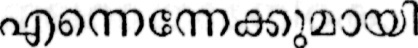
എന്നെന്നേക്കുമായി
